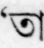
‘তা
